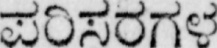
ಪರಿಸರಗಳ
